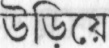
উড়িয়ে
